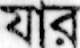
যার
